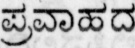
ಪ್ರವಾಹದ
